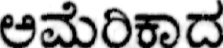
ಅಮೆರಿಕಾದ
